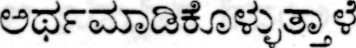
ಅರ್ಥಮಾಡಿಕೊಳ್ಳುತ್ತಾಳೆ
